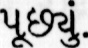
પૂછ્યું.
